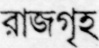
রাজগৃহ
